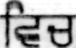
ਵਿਚ
